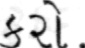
કરો.
